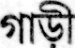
গাড়ী
